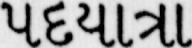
પદયાત્રા
